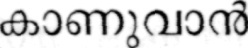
കാണുവാന്‍
